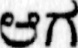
ಆಗ
